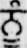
ਨੂੰ
